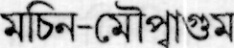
মচিন-মৌপ্বাগুম
